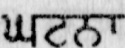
ਘਟਨਾ
